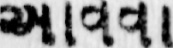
આવવા
